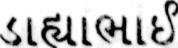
ડાહ્યાભાઈ
